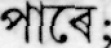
পাৰে;
